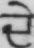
ਦੇ
